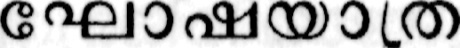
ഘോഷയാത്ര
